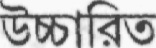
উচ্চারিত
